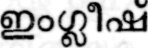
ഇംഗ്ലീഷ്
